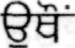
ਉਥੌਂ
